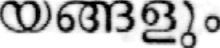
യങ്ങളും
